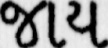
જાય
